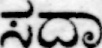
ಸದಾ
